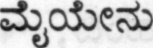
ಮೈಯೇನು
